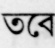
তবে
